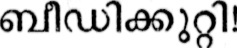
ബീഡിക്കുറ്റി!
